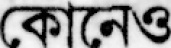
কোনেও
